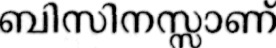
ബിസിനസ്സാണ്
